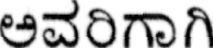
ಅವರಿಗಾಗಿ
